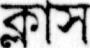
ক্লাস
